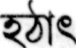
হঠাৎ
